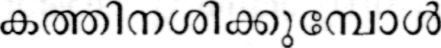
കത്തിനശിക്കുമ്പോള്‍
